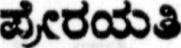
ಪ್ರೇರಯತಿ
